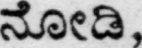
ನೋಡಿ,
